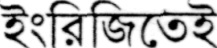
ইংরিজিতেই
